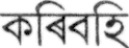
কৰিবহি
